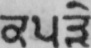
ਕਪੜੇ
